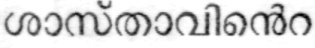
ശാസ്താവിന്റെ
